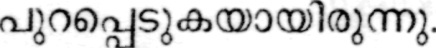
പുറപ്പെടുകയായിരുന്നു.
